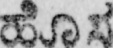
ಹೊಸ
